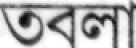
তবলা
